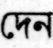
দেন
